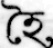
হৈ,
